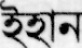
ইহান
